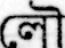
লৌ
